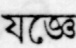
যজ্ঞে
